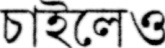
চাইলেও
